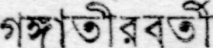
গঙ্গাতীরবর্তী
